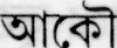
আকৌ
